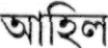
আহিল
